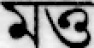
মত্ত
